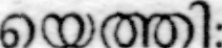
യെത്തി:
